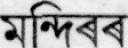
মন্দিৰৰ
